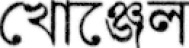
খোঞ্জেল
